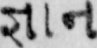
જ્ઞાન
